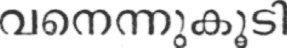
വനെന്നുകൂടി
